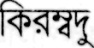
কিরম্বদু
